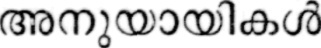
അനുയായികള്‍
